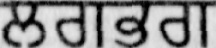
ਲਗਭਗ
